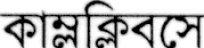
কাম্লক্লিবসে
